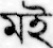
মই
